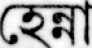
হেন্না
